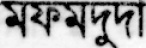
মফমদুদা
